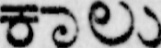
ಕಾಲು
